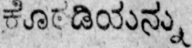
ಕೊಠಡಿಯನ್ನು
